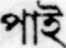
পাই
